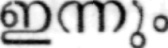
ഇന്നും
